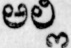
ಅಲ್ಲಿ
